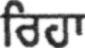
ਰਿਹਾ
